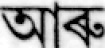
আৰু
